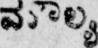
ಮೌಲ್ಯ
